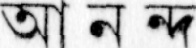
আনন্দ
